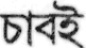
চাবই
